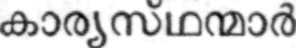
കാര്യസ്ഥന്മാര്‍
